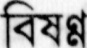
বিষণ্ণ
